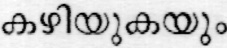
കഴിയുകയും
